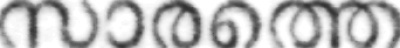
സാരത്തെ
